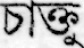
চাক্তু
